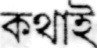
কথাই
